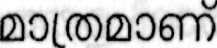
മാത്രമാണ്
